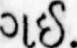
ગઈ.
